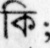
কি;
